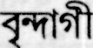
বৃন্দাগী
